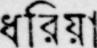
ধরিয়া
